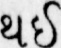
થઈ
